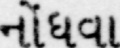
નોંધવા
